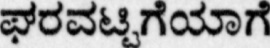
ಘರವಟ್ಟಿಗೆಯಾಗೆ
